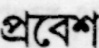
প্রবেশ
